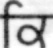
ਕਿ
